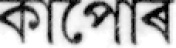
কাপোৰ
